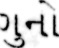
ગુનો
